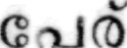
പേര്
